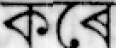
কৰে
